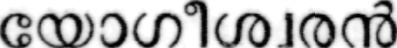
യോഗീശ്വരന്‍
